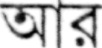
আর
